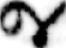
જ
